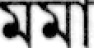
মমা
